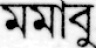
মমাবু
